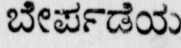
ಬೇರ್ಪಡೆಯ
